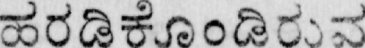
ಹರಡಿಕೊಂಡಿರುವ
